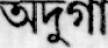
অদুগা
